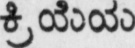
ಕ್ರಿಯೆಯ
